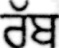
ਰੱਬ
